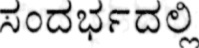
ಸಂದರ್ಭದಲ್ಲಿ
